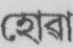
হোৱা
